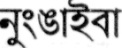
নুংঙাইবা
